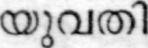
യുവതി
